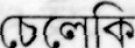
চেলেকি
